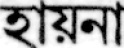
হায়না
